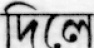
দিলে
